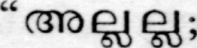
"അല്ലല്ല;
